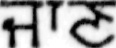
ਜਾਣ
